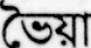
ভৈয়া
